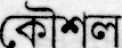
কৌশল
